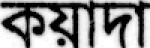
কয়াদা
